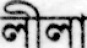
লীলা
